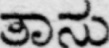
ತಾನು
